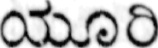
ಯೂರಿ
